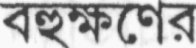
বহুক্ষণের
